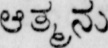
ಆತ್ಮನು
